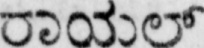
ರಾಯಲ್
